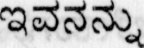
ಇವನನ್ನು
